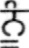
ਨੂੰ
